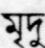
মৃদু
